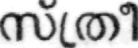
സ്ത്രീ
